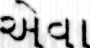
એવા
